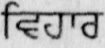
ਵਿਹਾਰ
